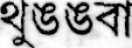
থুঙঙবা
